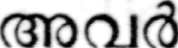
അവര്‍
